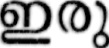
ഇരു
